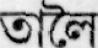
তালৈ
